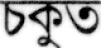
চকুত
